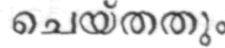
ചെയ്തതും
